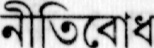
নীতিবোধ
